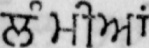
ਲੰਮੀਆਂ
